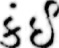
કંઈ
